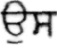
ਉਸ
